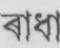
ৰাধা
